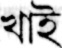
খাই
